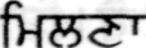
ਮਿਲਣਾ
